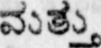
ಮತ್ತು
